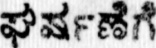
ಘರ್ಷಣೆಗೆ
